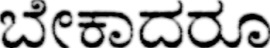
ಬೇಕಾದರೂ
